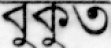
বুকুত
